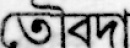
তৌবদা
